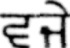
ਵਜੇ
